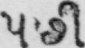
પછી
